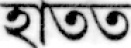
হাতত
